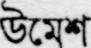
উমেশ
